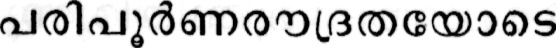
പരിപൂര്‍ണരൌദ്രതയോടെ
